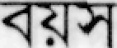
বয়স
